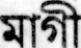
মাগী
